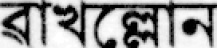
ৱাখল্লোন
